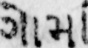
ગોમાં
